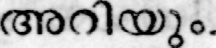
അറിയും.
